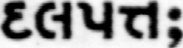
દલપત્ત;
